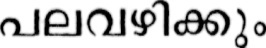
പലവഴിക്കും
